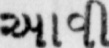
આવી
